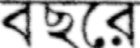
বছরে
